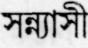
সন্ন্যাসী
